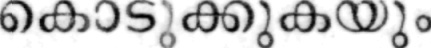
കൊടുക്കുകയും
